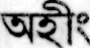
অহীং
